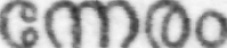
ന്നേരം
